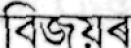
বিজয়ৰ
